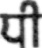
ਧੀ
